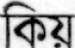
কিয়
